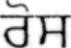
ਰੋਸ
